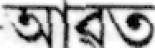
আৱত
